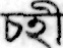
চহী
